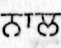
ਨਾਲ
